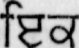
ਇਕ
